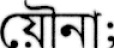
য়ৌনা;
